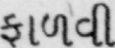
ફાળવી
